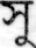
সু
